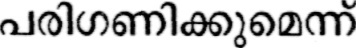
പരിഗണിക്കുമെന്ന്
